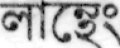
লান্থেং
